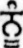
ਨੂੰ
